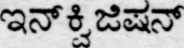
ಇನ್‌ಕ್ವಿಜಿಷನ್
